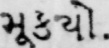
મૂક્યો.
